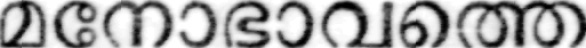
മനോഭാവത്തെ
